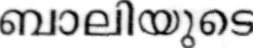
ബാലിയുടെ
